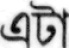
এটা
